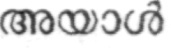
അയാള്‍
